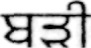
ਬੜੀ
